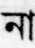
না
